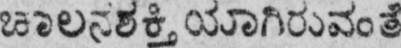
ಚಾಲನಶಕ್ತಿಯಾಗಿರುವಂತೆ
